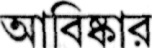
আবিষ্কার
